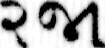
રજા
